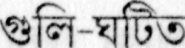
গুলি-ঘটিত
